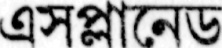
এসপ্লানেড
